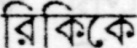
রিকিকে
